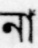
না
